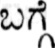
ಬಗ್ಗೆ
